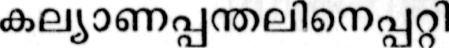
കല്യാണപ്പന്തലിനെപ്പറ്റി
